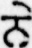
ਨੇ
